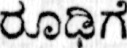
ರೂಢಿಗೆ
